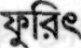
ফুরিৎ
